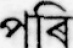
পৰি
